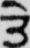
ਤੇ
